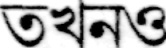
তখনও
